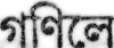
গণিলে
